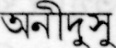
অনীদুসু
